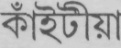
কাঁইটীয়া
